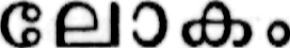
ലോകം
